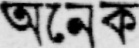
অনেক
